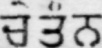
ਚੇਤੰਨ
